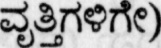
ವೃತ್ತಿಗಳಿಗೇ)
